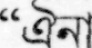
“ঐনা
